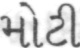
મોટી
